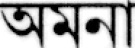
অমনা
